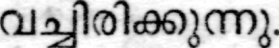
വച്ചിരിക്കുന്നു.
